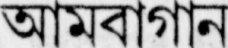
আমবাগান
